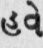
હવે
